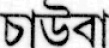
চাউবা
